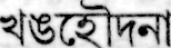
খঙহৌদনা
